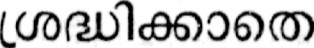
ശ്രദ്ധിക്കാതെ
